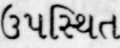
ઉપસ્થિત
